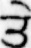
ਤੇ
